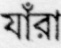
যাঁরা
